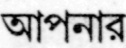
আপনার
